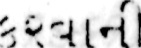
કરવાની
